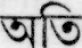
অতি
